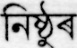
নিষ্ঠুৰ
